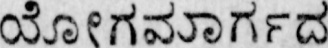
ಯೋಗಮಾರ್ಗದ
